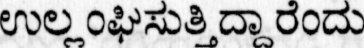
ಉಲ್ಲಂಘಿಸುತ್ತಿದ್ದಾರೆಂದು
